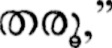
തരൂ,"
